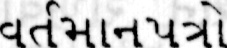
વર્તમાનપત્રો
